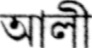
আলী
